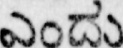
ಎಂದು
